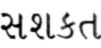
સશક્ત
